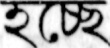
হচ্ছে
